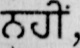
ਨਹੀਂ,
